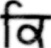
ਕਿ
